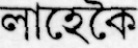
লাহেকৈ
